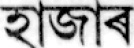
হাজাৰ
